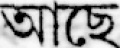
আছে
